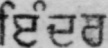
ਇੰਦਰ
